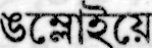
ঙম্লোইয়ে
